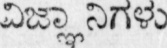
ವಿಜ್ಞಾನಿಗಳು
